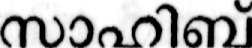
സാഹിബ്
